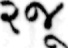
રજૂ
